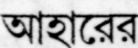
আহারের
